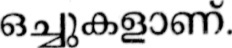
ഒച്ചുകളാണ്.
